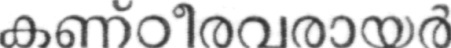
കണ്ഠീരവരായര്‍
